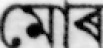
মোৰ
